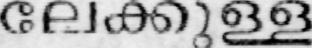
ലേക്കുള്ള
